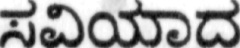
ಸವಿಯಾದ
